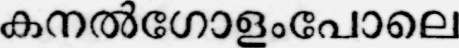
കനല്‍ഗോളംപോലെ
